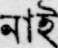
নাই
